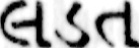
લડત
